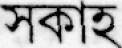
সকাহ
